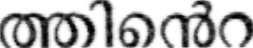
ത്തിന്റെ
